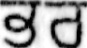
ਭਰ
